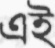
এই
